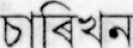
চাৰিখন
